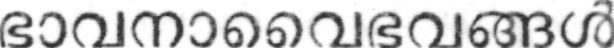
ഭാവനാവൈഭവങ്ങള്‍
